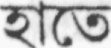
হাতে
